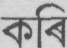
কৰি
